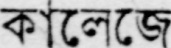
কালেজে
